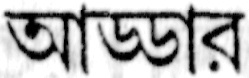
আড্ডার
